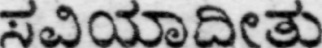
ಸವಿಯಾದೀತು
